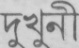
দুখুনী
